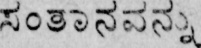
ಸಂತಾನವನ್ನು
